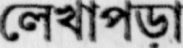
লেখাপড়া
